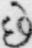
છે
